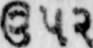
ઉપર
